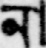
না
